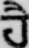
ਹੈ
